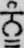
ਨੂੰ
